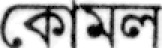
কোমল
